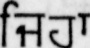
ਜਿਹਾ
